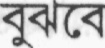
বুঝবে
